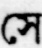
সে
